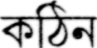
কঠিন
